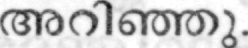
അറിഞ്ഞു.
